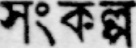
সংকল্প
